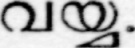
വയ്യ.
